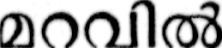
മറവില്‍
